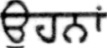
ਉਹਨਾਂ
